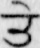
ਤੇ
